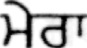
ਮੇਰਾ
